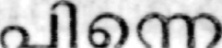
പിന്നെ
